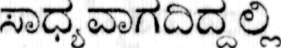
ಸಾಧ್ಯವಾಗದಿದ್ದಲ್ಲಿ
